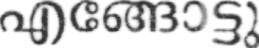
എങ്ങോട്ടു
